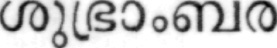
ശുഭ്രാംബര
